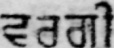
ਵਰਗੀ
